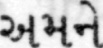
અમને
